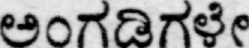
ಅಂಗಡಿಗಳೇ
